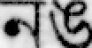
নঙ
